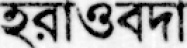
হরাওবদা
